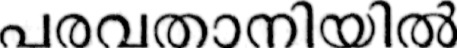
പരവതാനിയില്‍
